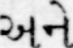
અને
